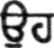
ਉਹ
